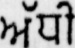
ਅੱਧੀ
